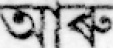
আৰু
